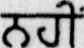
ਨਹੀਂ
